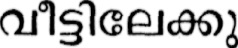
വീട്ടിലേക്കു
